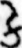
કે
